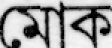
মোক
